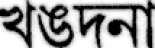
খঙদনা
